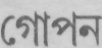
গোপন
